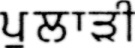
ਪੁਲਾੜੀ
